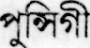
পুন্সিগী
